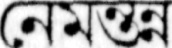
নেমম্তন্ন
